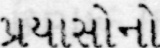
પ્રયાસોનો
